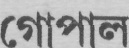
গোপাল
